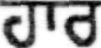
ਹਾਰ
